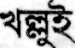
খল্লুই
